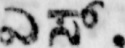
ಎಸ್.
